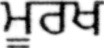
ਮੂਰਖ
